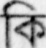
কি
